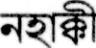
নহাক্কী
